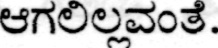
ಆಗಲಿಲ್ಲವಂತೆ.
